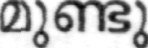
മുണ്ടു
